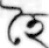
হৈ
